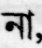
না,
